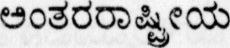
ಅಂತರರಾಷ್ಟ್ರೀಯ
